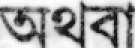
অথবা
